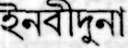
ইনবীদুনা
